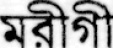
মরীগী
